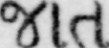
જાત
